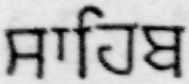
ਸਾਹਿਬ
